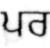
ਪਰ
